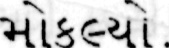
મોકલ્યો.
